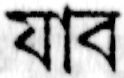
যাব
